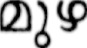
മുഴ
